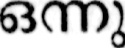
ഒന്നു
